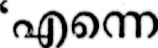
'എന്നെ
